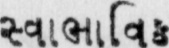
સ્વાભાવિક
